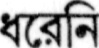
ধরেনি
